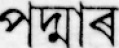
পদ্মাৰ
